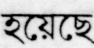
হয়েছে
